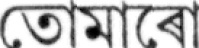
তোমাৰো
